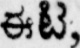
ಈಟಿ,
